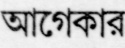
আগেকার
